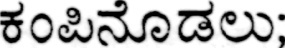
ಕಂಪಿನೊಡಲು;
